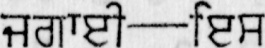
ਜਗਾਈ---ਇਸ
